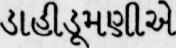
ડાહીડૂમણીને
